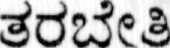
ತರಬೇತಿ
